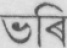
ভৰি
